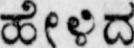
ಹೇಳಿದ
